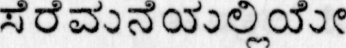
ಸೆರೆಮನೆಯಲ್ಲಿಯೇ
